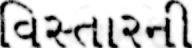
વિસ્તારની
